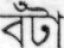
বঁটা
